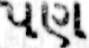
પણ
